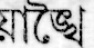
য়াঙ্খৈ
